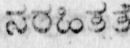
ನರಹಿತತೆ
